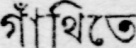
গাঁথিতে
